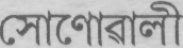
সোণোৱালী
